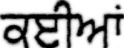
ਕਈਆਂ
